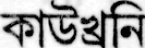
কাউখ্রনি
